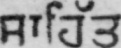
ਸਾਹਿੱਤ
